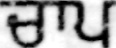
ਚਾਪ
